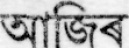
আজিৰ
